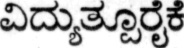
ವಿದ್ಯುತ್ಪೂರೈಕೆ
